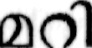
മറി
